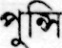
পুন্সি
